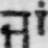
ਜਾਂ
